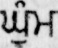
ਘੁੰਮ
